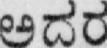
ಅದರ
